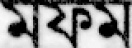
মফম
